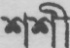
শশী
